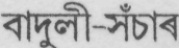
বাদুলী-সঁচাৰ
